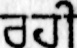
ਰਹੀ
